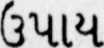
ઉપાય
